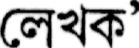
লেখক'
